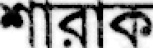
শারাক
